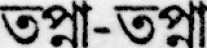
তপ্না-তপ্না
